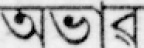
অভাৱ
